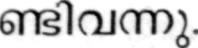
ണ്ടിവന്നു.
